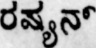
ರಷ್ಯನ್
